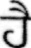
ਹੈ
